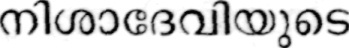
നിശാദേവിയുടെ
